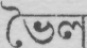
ভৈল
